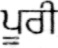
ਪੂਰੀ
